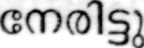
നേരിട്ടു
